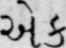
એક
